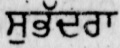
ਸੁਭੱਦਰਾ
